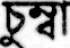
চুম্বা
